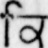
ਕਿ
